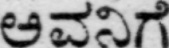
ಅವನಿಗೆ
